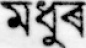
মধুৰ
